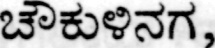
ಚೌಕುಳಿನಗ,
